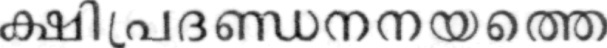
ക്ഷിപ്രദണ്ഡനനയത്തെ
